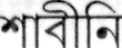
শাবীনি
